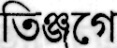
তিঞ্জগে
